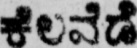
ಕೆಲವೆಡೆ
